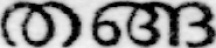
തങ്ങ
